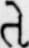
તે
